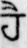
ਹੈ
